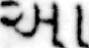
આ
